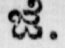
ಜೆ.
